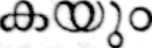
കയും
